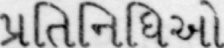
પ્રતિનિધિઓ
